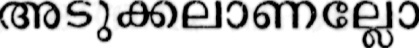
അടുക്കലാണല്ലോ
